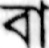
বা
